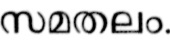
സമതലം.
